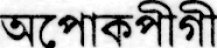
অপোকপীগী
